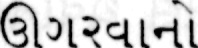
ઊગરવાનો
